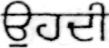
ਉਹਦੀ
